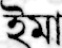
ইমা
